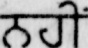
ਨਹੀਂ
